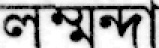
লম্মন্দা
